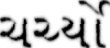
ચર્ચ્યો
